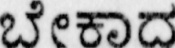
ಬೇಕಾದ
